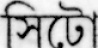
সিটো
